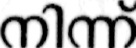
നിന്ന്
